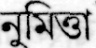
নুমিত্তা
